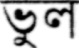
ভুল
